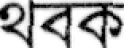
থবক
